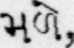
મળે,
